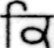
ਕਿ
